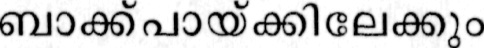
ബാക്ക്പായ്ക്കിലേക്കും
